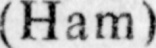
(Ham)
